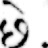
છે.
